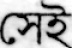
সেই
